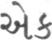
એક
